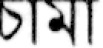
চামা
